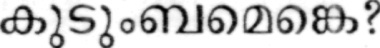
കുടുംബമെങ്കെ?
